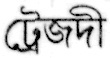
ট্রেজদী
